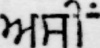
ਅਸੀਂ
